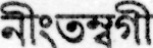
নীংতম্বগী
